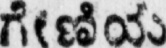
ಗೇಣಿಯ
